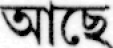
আছে
